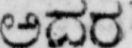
ಅದರ
